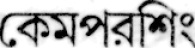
কেমপরশিং
